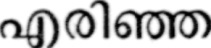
എരിഞ്ഞ
